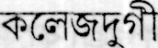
কলেজদুগী
